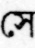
সে
